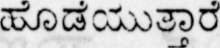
ಹೊಡೆಯುತ್ತಾರೆ
